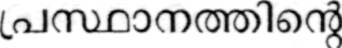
പ്രസ്ഥാനത്തിന്റെ
